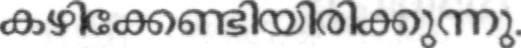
കഴിക്കേണ്ടിയിരിക്കുന്നു.
